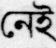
নেই
